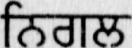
ਨਿਗਲ
